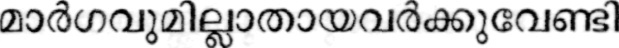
മാര്‍ഗവുമില്ലാതായവര്‍ക്കുവേണ്ടി
